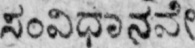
ಸಂವಿಧಾನವೇ
